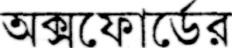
অক্সফোর্ডের
